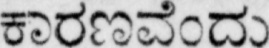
ಕಾರಣವೆಂದು
